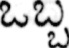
ಒಬ್ಬ
